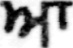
ਆ
